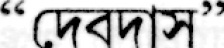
“দেবদাস”
